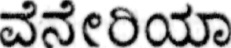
ವೆನೇರಿಯಾ
